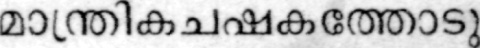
മാന്ത്രികചഷകത്തോടു
